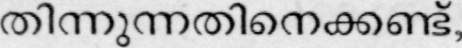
തിന്നുന്നതിനെക്കണ്ട്,
